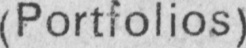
(Portolios)
